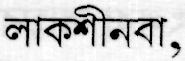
লাকশীনবা,
